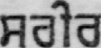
ਸਰੀਰ
